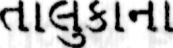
તાલુકાના
